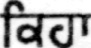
ਕਿਹਾ
